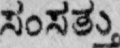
ಸಂಸತ್ತು
